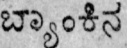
ಬ್ಯಾಂಕಿನ
